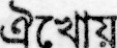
ঐখোয়
